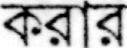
করার
